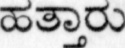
ಹತ್ತಾರು
